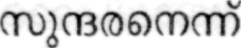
സുന്ദരനെന്ന്
